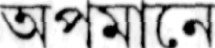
অপমানে
